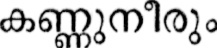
കണ്ണുനീരും
